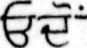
ਓਦੋਂ
